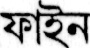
ফাইন
